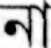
না
